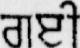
ਗਈ
